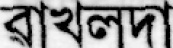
ৱাখলদা
